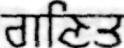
ਗਣਿਤ
